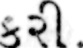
કરી.
